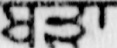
ਬੜਾ
